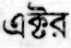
এক্টর
